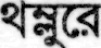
থম্লুরে
